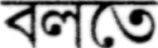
বলতে
